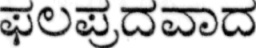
ಫಲಪ್ರದವಾದ
